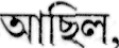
আছিল,
